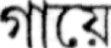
গায়ে
